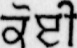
ਕੋਈ
